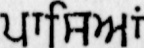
ਪਾਸਿਆਂ
